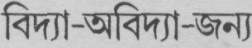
বিদ্যা-অবিদ্যা-জন্য
